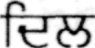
ਦਿਲ
